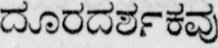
ದೂರದರ್ಶಕವು
